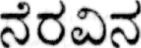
ನೆರವಿನ
